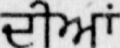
ਦੀਆਂ
